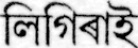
লিগিৰাই
